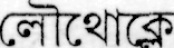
লৌথোক্লে
